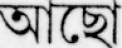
আছো
